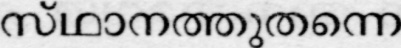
സ്ഥാനത്തുതന്നെ
